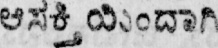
ಆಸಕ್ತಿಯಿಂದಾಗಿ
